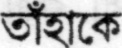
তাঁহাকে
